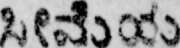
ಸೀಮೆಯ
